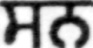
ਸਨ
